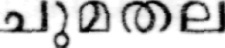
ചുമതല
